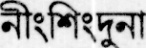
নীংশিংদুনা
